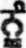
ਨੂੰ
